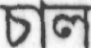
চাল
